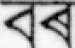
বৰ
